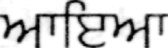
ਆਇਆ
